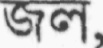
জল,
